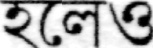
হলেও
